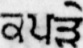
ਕਪੜੇ
